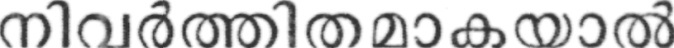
നിവര്‍ത്തിതമാകയാല്‍
